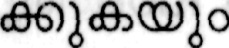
ക്കുകയും
